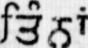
ਤਿੰਨਾਂ
